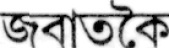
জবাতকৈ
